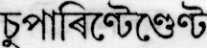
চুপাৰিণ্টেণ্ডেণ্ট
